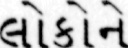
લોકોને
